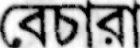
বেচারা
